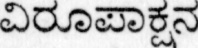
ವಿರೂಪಾಕ್ಷನ
